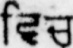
ਵਿਚ
